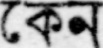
কেন
